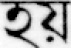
হয়
